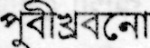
পুবীখ্রবনো
